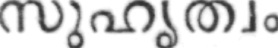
സുഹൃത്വം
